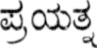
ಪ್ರಯತ್ನ
